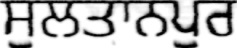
ਸੁਲਤਾਨਪੁਰ
